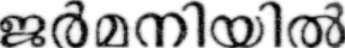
ജര്‍മനിയില്‍
